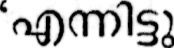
‘എന്നിട്ടു
